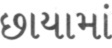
છાયામાં
